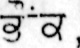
ਭੌਂਕ,
